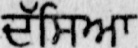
ਦੱਸਿਆ
